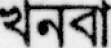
খনবা
